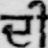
ਦੀ
